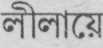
লীলায়ে
